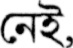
নেই,
